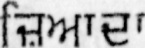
ਜ਼ਿਆਦਾ
